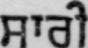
ਸਾਰੀ
